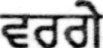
ਵਰਗੇ
